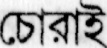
চোরাই
